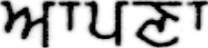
ਆਪਣਾ
